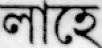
লাহে
